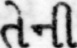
તેની
